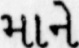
માને
